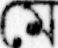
মে
